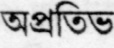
অপ্রতিভ
